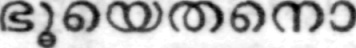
ഭൂയെതനൊ
